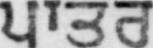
ਪਾਤਰ
